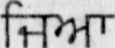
ਜਿਆ
